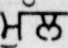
ਮੁੱਲ
